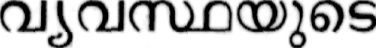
വ്യവസ്ഥയുടെ
